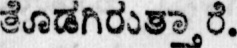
ತೊಡಗಿರುತ್ತಾರೆ.
